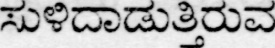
ಸುಳಿದಾಡುತ್ತಿರುವ
